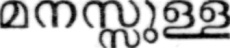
മനസ്സുള്ള
